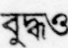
বুদ্ধও
